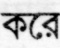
করে
